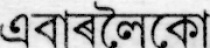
এবাৰলৈকো
